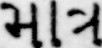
માત્ર
